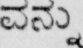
ವನ್ನು
